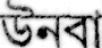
উনবা
